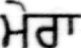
ਮੇਰਾ
